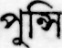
পুন্সি
